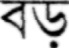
বড়
